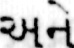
અને
